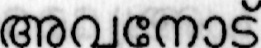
അവനോട്
